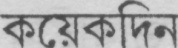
কয়েকদিন
